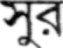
সুর
